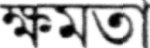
ক্ষমতা
